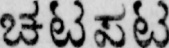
ಚಟಪಟ
